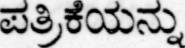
ಪತ್ರಿಕೆಯನ್ನು
